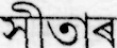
সীতাৰ
